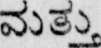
ಮತ್ತು
